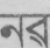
নৱ
